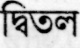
দ্বিতল
